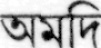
অমদি
